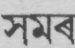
সমৰ
